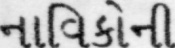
નાવિકોની
